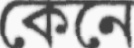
কেনে
